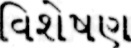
વિશેષણ
